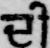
ਦੀ
